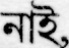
নাই,
